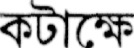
কটাক্ষে
